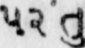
પરંતુ
